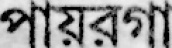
পায়রগা
